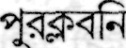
পুরক্লবনি
